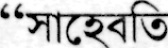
“সাহেবতি
